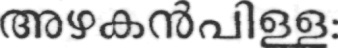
അഴകന്‍പിള്ള:
